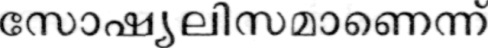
സോഷ്യലിസമാണെന്ന്
